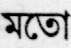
মতো
